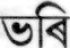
ভৰি
